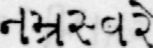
નમ્રસ્વરે
